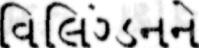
વિલિંગ્ડનને
